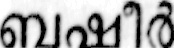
ബഷീര്‍
